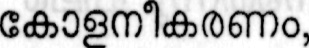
കോളനീകരണം,
